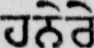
ਹਨੇਰੇ
